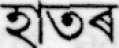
হাতৰ
